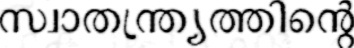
സ്വാതന്ത്ര്യത്തിന്റെ
